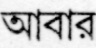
আবার
